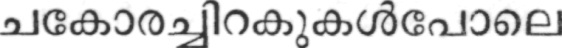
ചകോരച്ചിറകുകള്‍പോലെ
